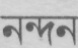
নন্দন
